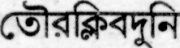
তৌরক্লিবদুনি
